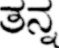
ತನ್ನ
